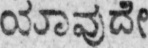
ಯಾವುದೇ
